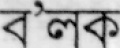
ব'লক
